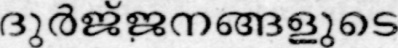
ദുര്‍ജ്ജനങ്ങളുടെ
